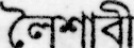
লৈশাবী
